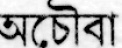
অচৌবা
